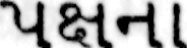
પક્ષના
